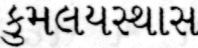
કુમલયસ્થાસ
